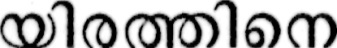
യിരത്തിനെ
